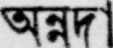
অন্নদা
